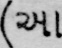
(આ
